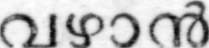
വഴാന്‍
